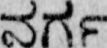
ವರ್ಗ
